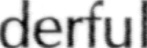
derful
